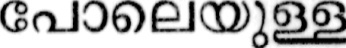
പോലെയുള്ള
